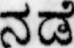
ನಡೆ
